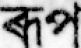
ৰূপ
